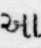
આ
